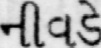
નીવડે
